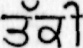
ਤੱਕੀ
